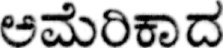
ಅಮೆರಿಕಾದ
